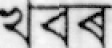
খবৰ
